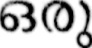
ഒരു
